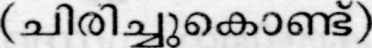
(ചിരിച്ചുകൊണ്ട്)
